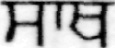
ਸਾਥ
